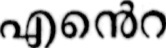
എന്റെ
